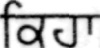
ਕਿਹਾ
